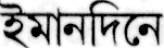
ইমানদিনে
